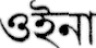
ওইনা
